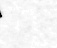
সিং
